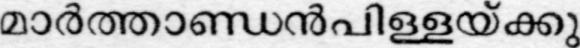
മാര്‍ത്താണ്ഡന്‍പിള്ളയ്ക്കു
